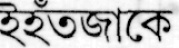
ইহঁতজাকে
